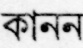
কানন
